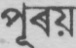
পূৰয়
